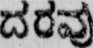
ದರವು
